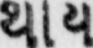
થાય
